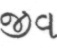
જીવ
